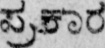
ಪ್ರಕಾರ
